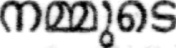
നമ്മുടെ
